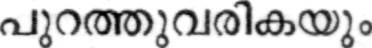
പുറത്തുവരികയും
